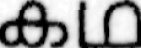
കഥ
